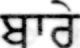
ਬਾਰੇ
